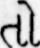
તો
